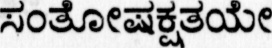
ಸಂತೋಷಕ್ಷತಯೇ
